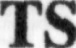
TS
